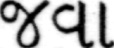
જવા
